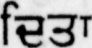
ਦਿਤਾ
